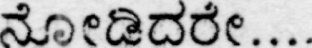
ನೋಡಿದರೇ....
